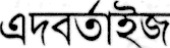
এদবর্তাইজ
